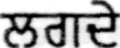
ਲਗਦੇ
